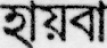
হায়বা
